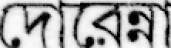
দোরেন্না
